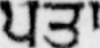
ਪਤਾ
